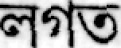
লগত
